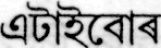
এটাইবোৰ
